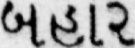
બહાર
